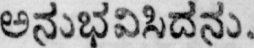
ಅನುಭವಿಸಿದನು.
